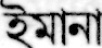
ইমানা
